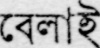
বেলাই
